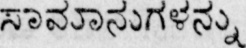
ಸಾಮಾನುಗಳನ್ನು
